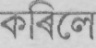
কৰিলে
